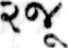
રજૂ
